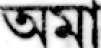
অমা
